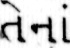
તેનાં
